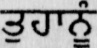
ਤੁਹਾਨੂੰ
